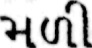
મળી
